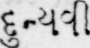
દુન્યવી
